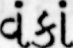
વંકાં
